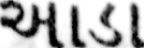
આડા
